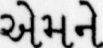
એમને
